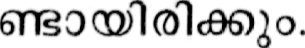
ണ്ടായിരിക്കും.
